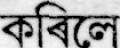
কৰিলে
